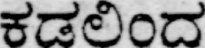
ಕಡಲಿಂದ
